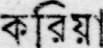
করিয়া
